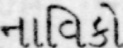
નાવિકો
